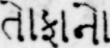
તોફાનો
